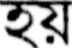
হয়
